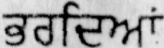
ਭਰਦਿਆਂ
